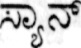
ಸ್ಯಾನ್
